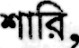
শারি,
